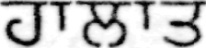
ਹਾਲਾਤ
